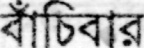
বাঁচিবার
